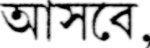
আসবে,
